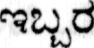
ಇಬ್ಬರ
